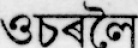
ওচৰলৈ
